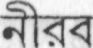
নীরব
